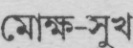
মোক্ষ-সুখ
